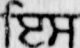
ਇਸ
